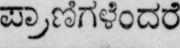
ಪ್ರಾಣಿಗಳೆಂದರೆ
